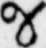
જ
